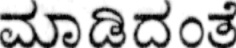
ಮಾಡಿದಂತೆ
